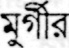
মুর্গীর
